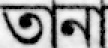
তানা
